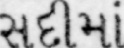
સદીમાં
